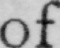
of
